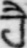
ਹੈ
